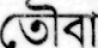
তৌবা
